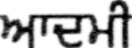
ਆਦਮੀ
